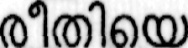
രീതിയെ
